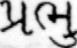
પ્રભુ
